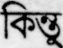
কিন্তু
